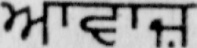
ਆਵਾਜ਼
